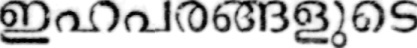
ഇഹപരങ്ങളുടെ
